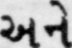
અને
